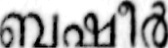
ബഷീര്‍
